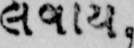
લવાય,
